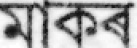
মাকৰ
